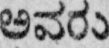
ಅವರು
